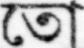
তো
